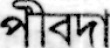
পীবদা
